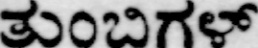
ತುಂಬಿಗಳ್
